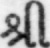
શ્રી
